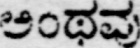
ಅಂಥವು
